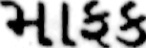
માફક
